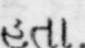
હતા.
